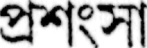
প্রশংসা
